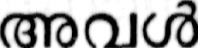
അവള്‍
